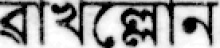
ৱাখল্লোন
